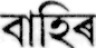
বাহিৰ
